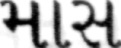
માસ
